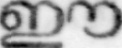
ഈ
